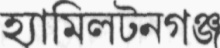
হ্যামিলটনগঞ্জ
